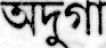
অদুগা
